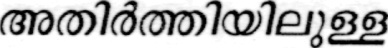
അതിര്‍ത്തിയിലുള്ള
